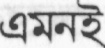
এমনই
